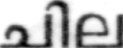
ചില
